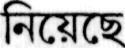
নিয়েছে
